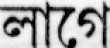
লাগে
